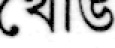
খোঙ
